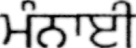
ਮੰਨਾਈ
